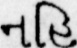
નહિ
